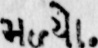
મળ્યો.
